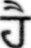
ਹੈ
